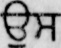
ਉਸ
